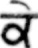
ਕੇ
